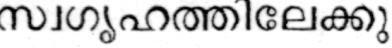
സ്വഗൃഹത്തിലേക്കു
